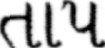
તાપ
